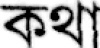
কথা
